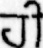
ਹੀ
